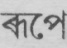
ৰূপে
